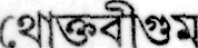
থোক্তবীগুম
